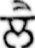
ਲੈ
